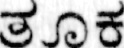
ತೂಕ
